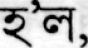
হ'ল,
